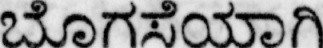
ಬೊಗಸೆಯಾಗಿ
